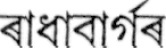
ৰাধাবার্গৰ
